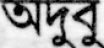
অদুবু
